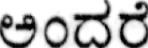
ಅಂದರೆ
